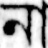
না
